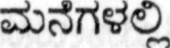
ಮನೆಗಳಲ್ಲಿ
